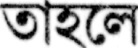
তাহলে
